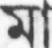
মা
